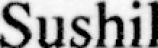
Sushil
